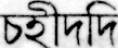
চহীদদি
